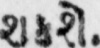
શકશે.
